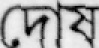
দোষ
